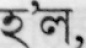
হ'ল,
